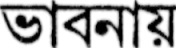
ভাবনায়
